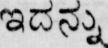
ಇದನ್ನು
